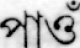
পাওঁ
